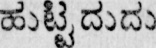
ಹುಟ್ಟಿದುದು
